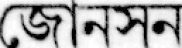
জোনসন
